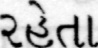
રહેતા
